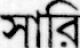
সারি
